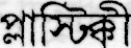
প্লাস্টিক্কী
